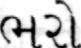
ભરો
